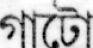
গাটো
